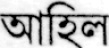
আহিল
